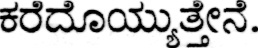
ಕರೆದೊಯ್ಯುತ್ತೇನೆ.
